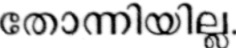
തോന്നിയില്ല.
